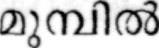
മുമ്പില്‍
